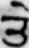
ਤੇ
